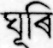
ঘূৰি
